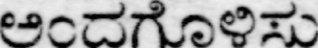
ಅಂದಗೊಳಿಸು
